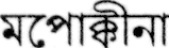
মপোক্কীনা
